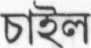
চাইল
